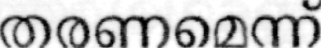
തരണമെന്ന്
